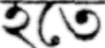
হতে
